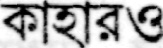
কাহারও
